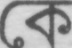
কে
